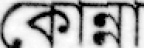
কোন্না
